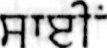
ਸਾਈਂ
